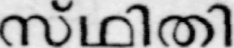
സ്ഥിതി
